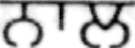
ਨਾਲ
